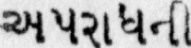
અપરાધની
